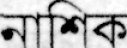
নাশিক
